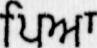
ਪਿਆ
